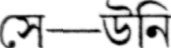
সে–উনি
